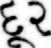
દૂર
